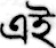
এই
